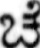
ಚೆ
